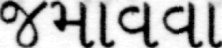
જમાવવા
